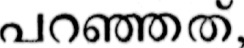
പറഞ്ഞത്,
